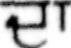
ਦਾ
